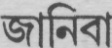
জানিবা
